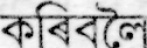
কৰিবলৈ
